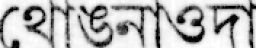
থোঙনাওদা
